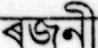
ৰজনী
